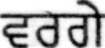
ਵਰਗੇ
